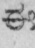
ಈ
